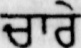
ਚਾਰੇ
